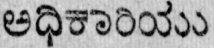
ಅಧಿಕಾರಿಯು
